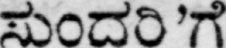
ಸುಂದರಿ'ಗೆ
